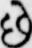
છે
